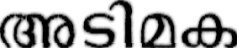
അടിമക
